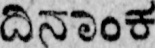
ದಿನಾಂಕ
